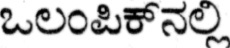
ಒಲಂಪಿಕ್‌ನಲ್ಲಿ
